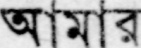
আমার
